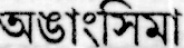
অঙাংসিমা
